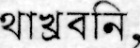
থাখ্রবনি,
